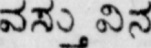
ವಸ್ತುವಿನ
